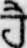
ਹੈ
